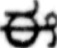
ಈ
